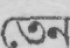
তেন
